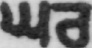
ਘਰ
